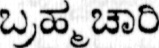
ಬ್ರಹ್ಮಚಾರಿ
